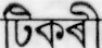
টিকৰী
